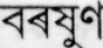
বৰষুণ
